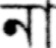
না
